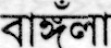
বাঙ্গঁলা
